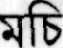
মচি
